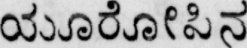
ಯೂರೋಪಿನ
